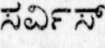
ಸರ್ವಿಸ್
